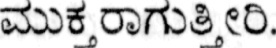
ಮುಕ್ತರಾಗುತ್ತೀರಿ.
